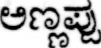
ಅಣ್ಣಪ್ಪು
